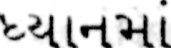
ધ્યાનમાં
